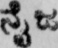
ನೈಜ
